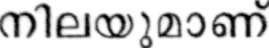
നിലയുമാണ്
